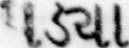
પડ્યા
